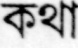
কথা
